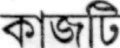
কাজটি
